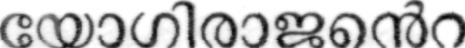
യോഗിരാജന്റെ
